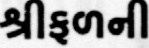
શ્રીફળની
